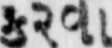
કરવા
